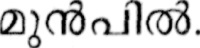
മുന്‍പില്‍.
